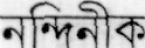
নন্দিনীক
